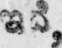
ಇದೆ,
